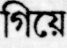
গিয়ে
